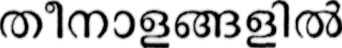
തീനാളങ്ങളില്‍
